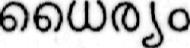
ധൈര്യം
